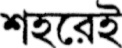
শহরেই
